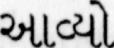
આવ્યો
